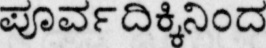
ಪೂರ್ವದಿಕ್ಕಿನಿಂದ
